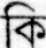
কি
